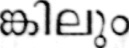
ങ്കിലും
